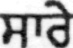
ਸਾਰੇ
